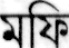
মফি
